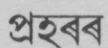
প্রহৰৰ
